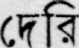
দেরি
